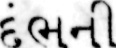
દંભની
